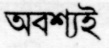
অবশ্যই
